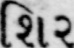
શિર
